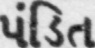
પંડિતે
